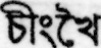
চীংখৈ
